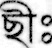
ছীঃ
